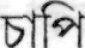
চাপি
